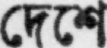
দেশে
